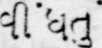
વીંધતુ
